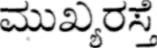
ಮುಖ್ಯರಸ್ತೆ
